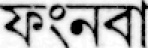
ফংনবা
